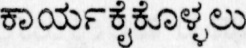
ಕಾರ್ಯಕೈಕೊಳ್ಳಲು
